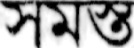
সমস্ত
